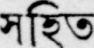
সহিত
